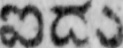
ಐದು
